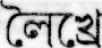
লৈখ্রে
